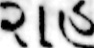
રાહ
